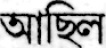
আছিল
